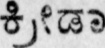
ಕ್ರೀಡಾ
